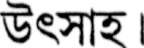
উৎসাহ।
